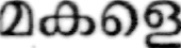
മകളെ
